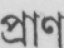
প্রাণ
